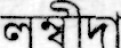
লম্বীদা
